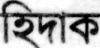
হিদাক
